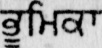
ਭੂਮਿਕਾ
